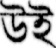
উই
